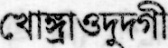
খোঙ্গ্রাওদুদগী
